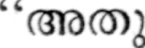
"അതു
